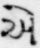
એ
